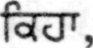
ਕਿਹਾ,
